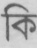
কি
